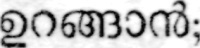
ഉറങ്ങാന്‍;
